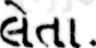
લેતા.
